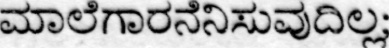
ಮಾಲೆಗಾರನೆನಿಸುವುದಿಲ್ಲ.
